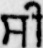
ਸੀ
